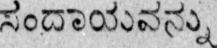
ಸಂದಾಯವನ್ನು
